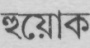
হুয়োক
